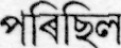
পৰিছিল
